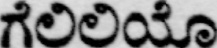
ಗೆಲಿಲಿಯೊ
